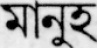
মানুহ
